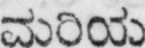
ಮರಿಯ
